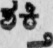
ಶಕ್ತಿ
